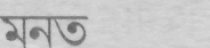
মনত
